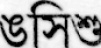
ঙসিশু
